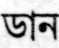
ডান
